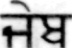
ਜੇਬ
